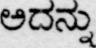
ಅದನ್ನು
